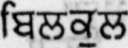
ਬਿਲਕੁਲ
